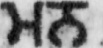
ਮਨ
